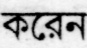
করেন
